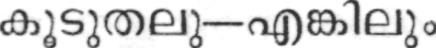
കൂടുതലു-എങ്കിലും
